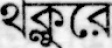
থক্লুরে
